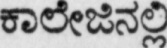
ಕಾಲೇಜಿನಲ್ಲಿ
